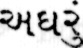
અઘરું
